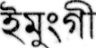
ইমুংগী
